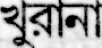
খুরানা
